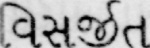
વિસર્જીત
